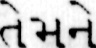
તેમને
